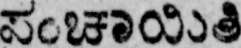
ಪಂಚಾಯಿತಿ
